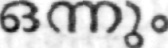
ഒന്നും
